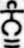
ਨੂੰ
